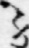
કે
